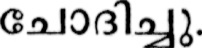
ചോദിച്ചു.
